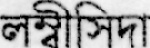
লম্বীসিদা
